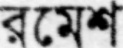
রমেশ
